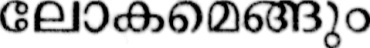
ലോകമെങ്ങും
